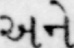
અને
